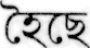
হৈছে
